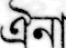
ঐনা
